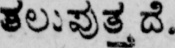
ತಲುಪುತ್ತದೆ.
